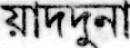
য়াদদুনা
